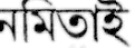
নমিতাই
